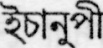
ইচানুপী
